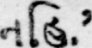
નહિ.
